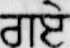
ਗਏ
